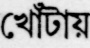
খোঁটায়
